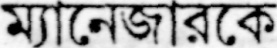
ম্যানেজারকে
